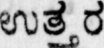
ಉತ್ತರ
